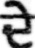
ਦੇ
